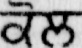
ਕੋਲ
